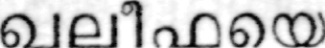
ഖലീഫയെ
